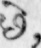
છે,
